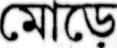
মোড়ে
